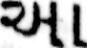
આ
